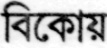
বিকোয়
